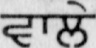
ਵਾਲੇ
